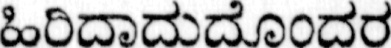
ಹಿರಿದಾದುದೊಂದರ
